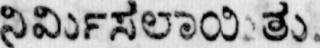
ನಿರ್ಮಿಸಲಾಯಿತು.
